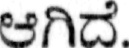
ಆಗಿದೆ.
